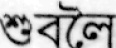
শুবলৈ
